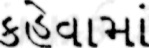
કહેવામાં
